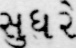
સુધરે
